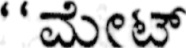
"ಮೇಟ್
